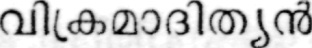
വിക്രമാദിത്യന്‍
